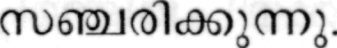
സഞ്ചരിക്കുന്നു.
